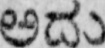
ಅದು
